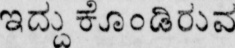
ಇದ್ದುಕೊಂಡಿರುವ
